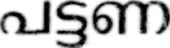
പട്ടണ
